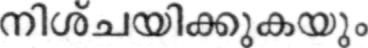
നിശ്ചയിക്കുകയും
